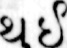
થઈ
